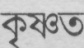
কৃষ্ণত
